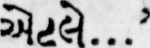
એટલે...'
